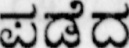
ಪಡೆದ
